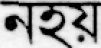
নহয়
